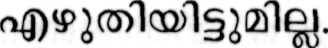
എഴുതിയിട്ടുമില്ല.
